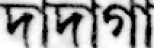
দাদাগা
